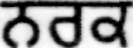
ਨਰਕ
